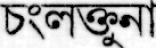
চংলক্তুনা
